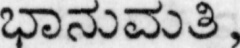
ಭಾನುಮತಿ,
